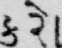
કરો
